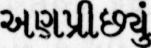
અણપ્રીછ્યું
